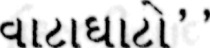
વાટાઘાટો"
